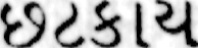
છટકાય
